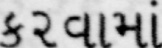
કરવામાં
